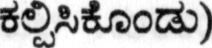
ಕಲ್ಪಿಸಿಕೊಂಡು)
